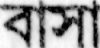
বাসা
